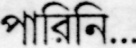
পারিনি...
